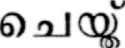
ചെയ്ത്
